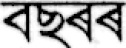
বছৰৰ
